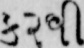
કરવી
